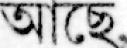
আছে,
